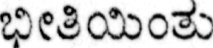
ಭೀತಿಯಿಂತು
